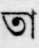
তা
